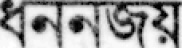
ধননজয়
